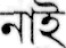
নাই
